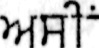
ਅਸੀਂ
